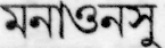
মনাওনসু
